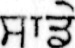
ਸਾਡੇ
